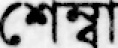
শেম্বা
